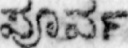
ಪೂರ್ವ
